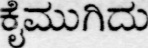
ಕೈಮುಗಿದು
